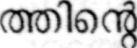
ത്തിന്റെ
